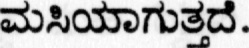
ಮಸಿಯಾಗುತ್ತದೆ.
